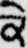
ਕੇ
